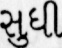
સુધી
